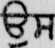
ਉਸ
